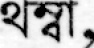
থম্বা,
